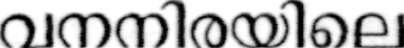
വനനിരയിലെ
